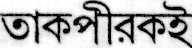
তাকপীরকই
